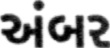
અંબર
